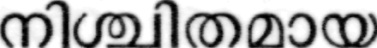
നിശ്ചിതമായ
